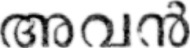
അവന്‍
